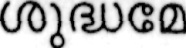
ശുദ്ധമേ
